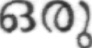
ഒരു
